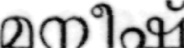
മനീഷ്
